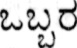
ಒಬ್ಬರ
